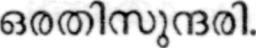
ഒരതിസുന്ദരി.
